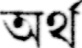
অর্থ
